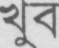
খুব
